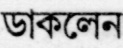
ডাকলেন
